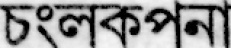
চংলকপনা
